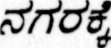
ನಗರಕ್ಕೆ
